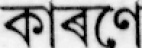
কাৰণে
